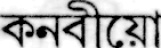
কনবীয়ো
